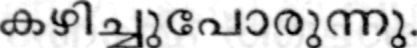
കഴിച്ചുപോരുന്നു.
